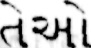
તેઓ
